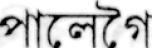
পালেগৈ
